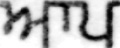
ਆਪ
